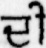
ਦੀ
